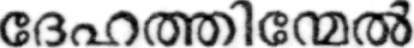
ദേഹത്തിന്മേല്‍
